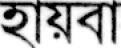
হায়বা
